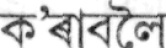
ক'ৰাবলৈ
